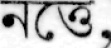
নত্তে,
